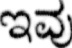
ಇವು
